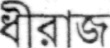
ধীরাজ
